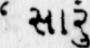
'સારું
